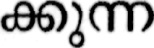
ക്കുന്ന
